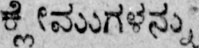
ಕ್ಲೇಮುಗಳನ್ನು
